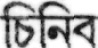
চিনিব
